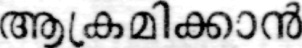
ആക്രമിക്കാന്‍
